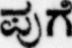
ಪುಗೆ
